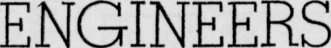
ENGINEERS
